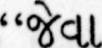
"જેવા
